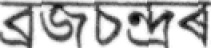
ব্রজচন্দ্রৰ
